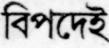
বিপদেই
